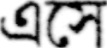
এসে
